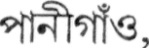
পানীগাঁও,
